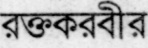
রক্তকরবীর
